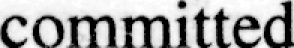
committed
